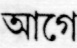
আগে
